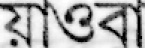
য়াওবা
